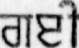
ਗਈ
